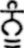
ਨੂੰ
